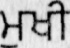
ਮੁਖੀ
